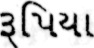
રૂપિયા
